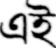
এই
